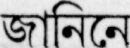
জানিনে
